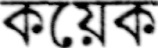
কয়েক
